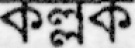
কল্লক
